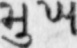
મુખ
